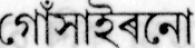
গোঁসাইৰনো
